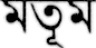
মতূম
